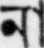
না
